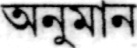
অনুমান
